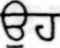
ਉਹ
